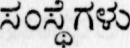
ಸಂಸ್ಥೆಗಳು
